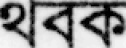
থবক
